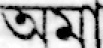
অমা
